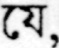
যে,
